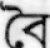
বৈ
